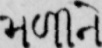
મળીને
